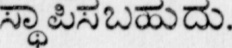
ಸ್ಥಾಪಿಸಬಹುದು.
